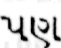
પણ
